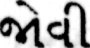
જોવી
